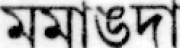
মমাঙদা
